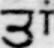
ਤਾਂ
